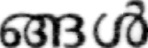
ങ്ങള്‍
